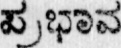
ಪ್ರಭಾವ
